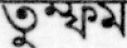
তুম্ফম
